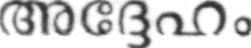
അദ്ദേഹം
